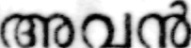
അവന്‍
